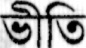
ভীতি
